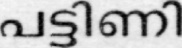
പട്ടിണി
